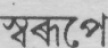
স্বৰূপে
